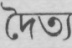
দৈত্য
